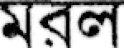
মরল
